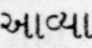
આવ્યા
